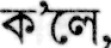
ক'লে,
